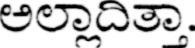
ಅಲ್ಲಾದಿತ್ತಾ.
